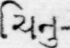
ચિનુ-
